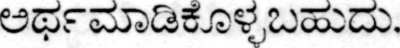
ಅರ್ಥಮಾಡಿಕೊಳ್ಳಬಹುದು.
